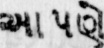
આપણે
